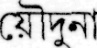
য়ৌদুনা
